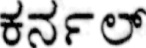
ಕರ್ನಲ್
